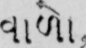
વાળો,
